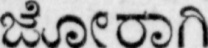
ಜೋರಾಗಿ
